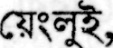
য়েংলুই,
